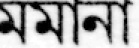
মমানা
